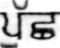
ਪੁੱਛ
